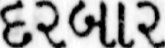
દરબાર
